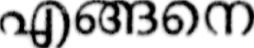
എങ്ങനെ
